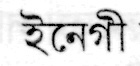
ইনেগী
